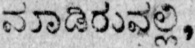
ಮಾಡಿರುವಲ್ಲಿ,
